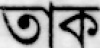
তাক
